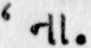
'ના.
